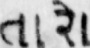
તારો
